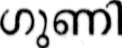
ഗുണി
